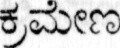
ಕ್ರಮೇಣ
